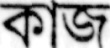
কাজ
